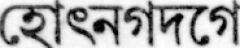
হোৎনগদগে
